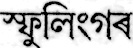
স্ফুলিংগৰ
